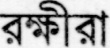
রক্ষীরা
